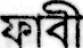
ফাবী
